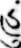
હું
